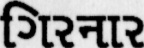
ગિરનાર
